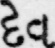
દેવ
